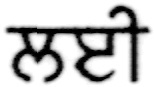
ਲਈ
